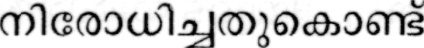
നിരോധിച്ചതുകൊണ്ട്
